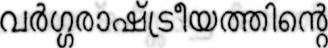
വര്‍ഗ്ഗരാഷ്ട്രീയത്തിന്റെ
